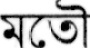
মতৌ
